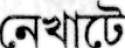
নেখাটে
